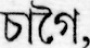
চাগৈ,
